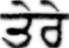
ਤੇਰੇ
